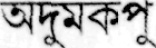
অদুমকপু
